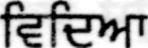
ਵਿਦਿਆ
